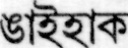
ঙাইহাক
